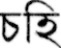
চহি
